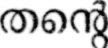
തന്റെ
